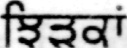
ਝਿੜਕਾਂ
